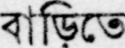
বাড়িতে
